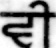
ਵੀ
